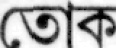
তোক
